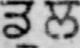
ਡੁਲ
